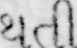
થતી
